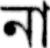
না
